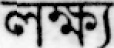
লক্ষ্য
